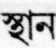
স্থান
